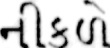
નીકળે
